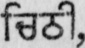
ਚਿਠੀ,
